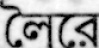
লৈরে
